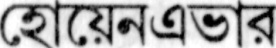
হোয়েনএভার
